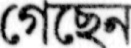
গেছেন
